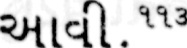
આવી.૧૧૩
